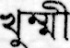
খুম্মী
